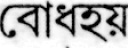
বোধহয়
